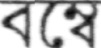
বম্বে
